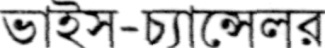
ভাইস-চ্যান্সেলর
